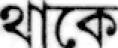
থাকে
